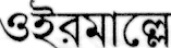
ওইরমাল্লে
